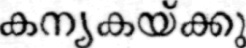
കന്യകയ്ക്കു
